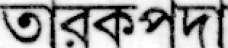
তারকপদা
